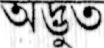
অদ্ভুত
